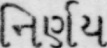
નિર્ણય
